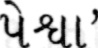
પેશ્વા'
